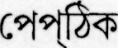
পেপ‌্ঠিক
